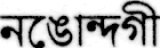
নঙোন্দগী
